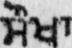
ਸੌਖਾ
